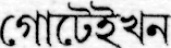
গোটেইখন
